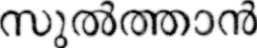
സുല്‍ത്താന്‍
